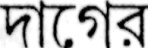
দাগের
